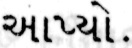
આપ્યો.
